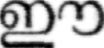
ഈ
